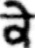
ਕੇ
